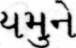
યમુને
